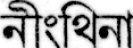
নীংথিনা
